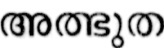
അത്ഭുത
